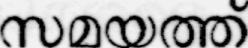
സമയത്ത്
